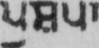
ਪੁਸ਼ਪਾ
